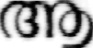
ആ
